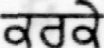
ਕਰਕੇ
